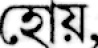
হোয়,
